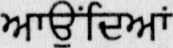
ਆਉਂਦਿਆਂ
